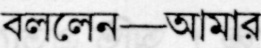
বললেন–আমার
